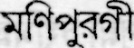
মণিপুরগী
